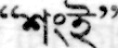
“শংই”
